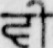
ਵੀ
